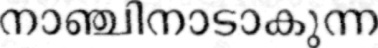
നാഞ്ചിനാടാകുന്ന
